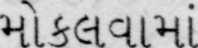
મોકલવામાં
